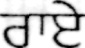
ਰਾਏ
